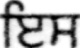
ਇਸ
